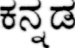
ಕನ್ನಡ
